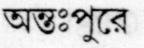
অন্তঃপুরে
